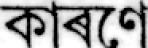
কাৰণে
